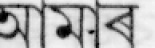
আমাৰ
